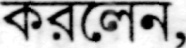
করলেন,
